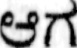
ಆಗ
